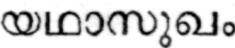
യഥാസുഖം
